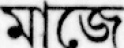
মাজে
